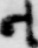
ન
